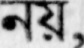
নয়,
